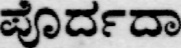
ಪೊರ್ದದಾ
